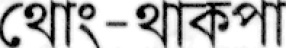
থোং-থাকপা
